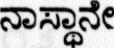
ನಾಸ್ಥಾನೇ
